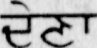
ਦੇਣਾ
